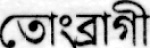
তোংব্রাগী
